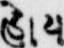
હોય
